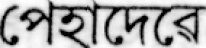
পেহাদেৱে
